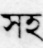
সহ
